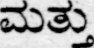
ಮತ್ತು
